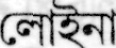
লোইনা
